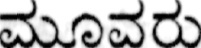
ಮೂವರು
